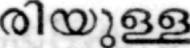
രിയുള്ള
